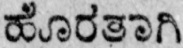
ಹೊರತಾಗಿ
